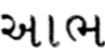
આભ
